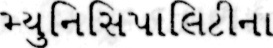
મ્યુનિસિપાલિટીના
